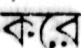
করে
